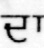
ਦਾ
